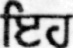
ਇਹ
